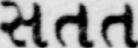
સતત
